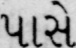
પાસે
